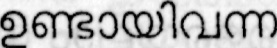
ഉണ്ടായിവന്ന
